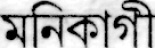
মনিকাগী
